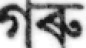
গৰু
